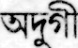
অদুগী
